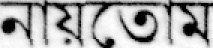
নায়তোম
